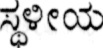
ಸ್ಥಳೀಯ
